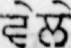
ਵੇਲੇ
